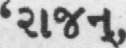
'રાજન્,
